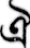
ঐ
